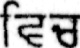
ਵਿਚ
